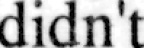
didn't
